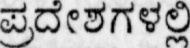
ಪ್ರದೇಶಗಳಲ್ಲಿ
